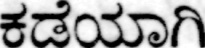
ಕಡೆಯಾಗಿ
